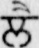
ਲੈ
